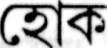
হোক
